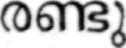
രണ്ടു
